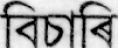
বিচাৰি
